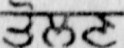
ਤੋਲਣ
